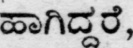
ಹಾಗಿದ್ದರೆ,
